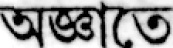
অজ্ঞাতে
